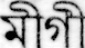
মীগী
